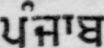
ਪੰਜਾਬ
